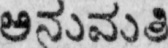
ಅನುಮತಿ
